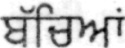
ਬੱਚਿਆਂ
